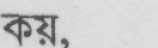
কয়,
